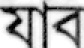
যাব
